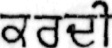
ਕਰਦੀ
